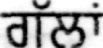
ਗੱਲਾਂ
